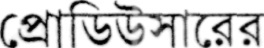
প্রোডিউসারের
